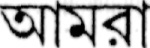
আমরা
